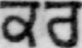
ਕਰ
